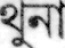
থুনা
